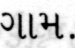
ગામ.
